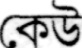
কেউ
